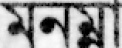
মনম্না
